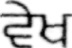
ਵੇਖ
